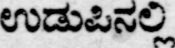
ಉಡುಪಿನಲ್ಲಿ
